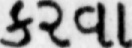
કરવા
